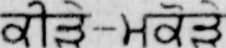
ਕੀੜੇ-ਮਕੋੜੇ
